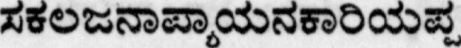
ಸಕಲಜನಾಪ್ಯಾಯನಕಾರಿಯಪ್ಪ
